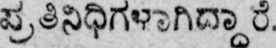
ಪ್ರತಿನಿಧಿಗಳಾಗಿದ್ದಾರೆ.
